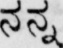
ನನ್ನ
